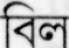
বিল
